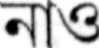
নাও
